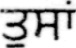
ਤੁਸਾਂ
